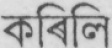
কৰিলি
